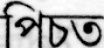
পিচত
